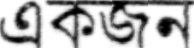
একজন
